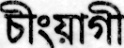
চীংয়াগী
